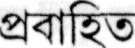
প্রবাহিত
